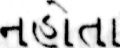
નહોતા
